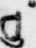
તું
